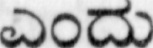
ಎಂದು
